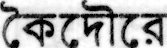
কৈদৌরে
